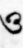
ও
